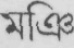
মঞি
